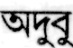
অদুবু
